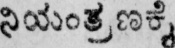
ನಿಯಂತ್ರಣಕ್ಕೆ
